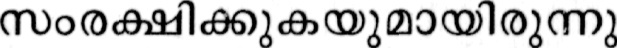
സംരക്ഷിക്കുകയുമായിരുന്നു
